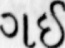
ગઈ
